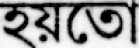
হয়তো
